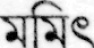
মমিৎ
